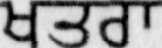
ਖਤਰਾ
